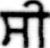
ਸੀ
